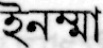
ইনম্মা
